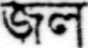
জল
